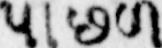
પાછળ
